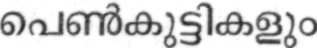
പെണ്‍കുട്ടികളും
